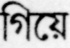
গিয়ে
